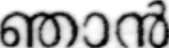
ഞാന്‍
